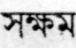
সক্ষম
